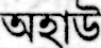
অহাউ
